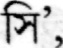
সি',
